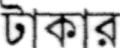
টাকার
